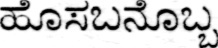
ಹೊಸಬನೊಬ್ಬ
